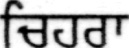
ਚਿਹਰਾ
